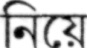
নিয়ে
